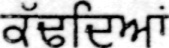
ਕੱਢਦਿਆਂ
